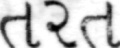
તરત
